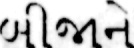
બીજાને
